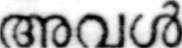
അവള്‍
